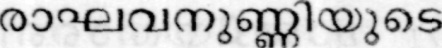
രാഘവനുണ്ണിയുടെ
